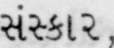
સંસ્કાર,
